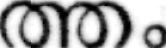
ത്തം
